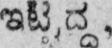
ಇಟ್ಟಿದ್ದ,
